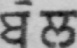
ਬੋਲ
